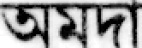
অমদা
